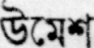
উমেশ
